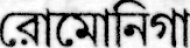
রোমোনিগা
